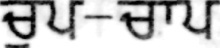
ਚੁਪ-ਚਾਪ
